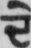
ਦੇ
